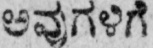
ಅವುಗಳಿಗೆ
